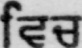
ਵਿਚ
